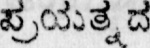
ಪ್ರಯತ್ನದ
